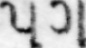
પગ
